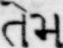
વધુ
